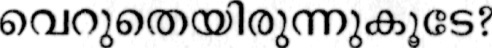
വെറുതെയിരുന്നുകൂടേ?
